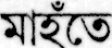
মাহঁতে
